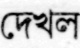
দেখল
